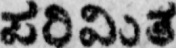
ಪರಿಮಿತ
